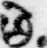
છે.
